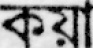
কয়া
